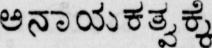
ಅನಾಯಕತ್ವಕ್ಕೆ
